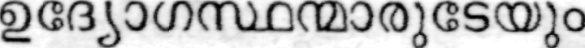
ഉദ്യോഗസ്ഥന്മാരുടേയും
